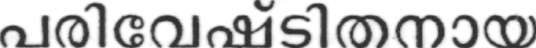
പരിവേഷ്ടിതനായ
